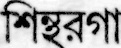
শিন্থরগা
